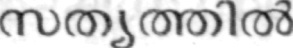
സത്യത്തില്‍
